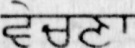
ਵੇਚਣਾ
